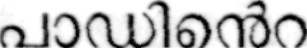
പാഡിന്റെ
